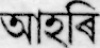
আহৰি
